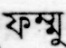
ফম্মু
